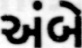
અંબે
